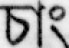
চাং
